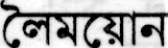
লৈময়োন
